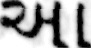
આ
